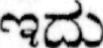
ಇದು
